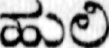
ಹುಲಿ
